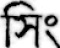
সিং
